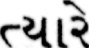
ત્યારે
